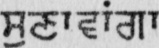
ਸੁਣਾਵਾਂਗਾ
